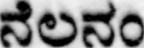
ನೆಲನಂ
